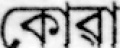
কোৱা
